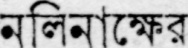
নলিনাক্ষের
